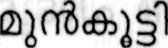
മുന്‍കൂട്ടി
